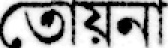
তোয়না
